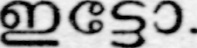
ഇട്ടോ.
